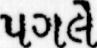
પગલે
